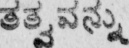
ತತ್ವವನ್ನು
